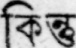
কিন্তু
